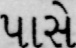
પાસે
